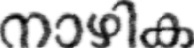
നാഴിക
